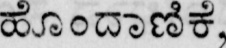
ಹೊಂದಾಣಿಕೆ,
